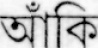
আঁকি
